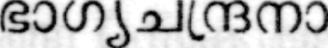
ഭാഗ്യചന്ദ്രനാ
